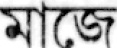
মাজে
